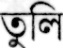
তুলি
